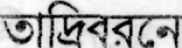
তাদ্রিবরনে
